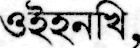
ওইহনখি,
